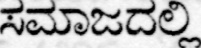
ಸಮಾಜದಲ್ಲಿ
